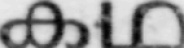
കഥ
